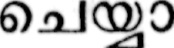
ചെയ്യാ
